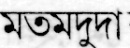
মতমদুদা
